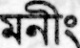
মনীং
